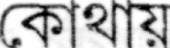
কোথায়
